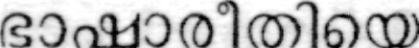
ഭാഷാരീതിയെ
